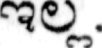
ಇಲ್ಲ.
